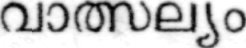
വാത്സല്യം
